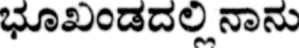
ಭೂಖಂಡದಲ್ಲಿನಾನು
